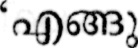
‘എങ്ങു
